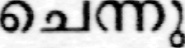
ചെന്നു
